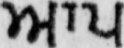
ਆਪ
